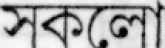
সকলো
